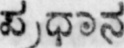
ಪ್ರಧಾನ
